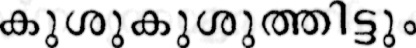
കുശുകുശുത്തിട്ടും
